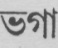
ভগা
